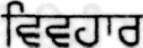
ਵਿਵਹਾਰ
